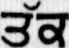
ਤੱਕ
